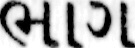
ભાગ
